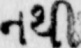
નથી
